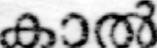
കാല്‍
